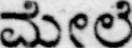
ಮೇಲೆ
